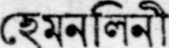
হেমনলিনী
